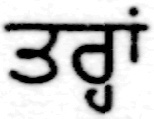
ਤਰ੍ਹਾਂ
